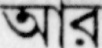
আর
